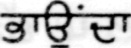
ਭਾਉਂਦਾ
